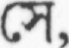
সে,
